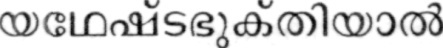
യഥേഷ്ടഭുക്തിയാല്‍
